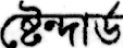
ষ্টেন্দর্ড
